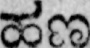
ಹಣ
